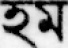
হম
